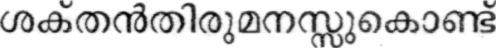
ശക്തന്‍തിരുമനസ്സുകൊണ്ട്
